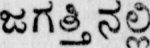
ಜಗತ್ತಿನಲ್ಲಿ
